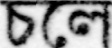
চলে
